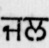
ਜਲ
